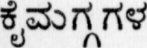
ಕೈಮಗ್ಗಗಳ
